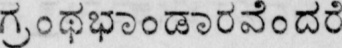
ಗ್ರಂಥಭಾಂಡಾರವೆಂದರೆ
